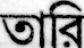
তারি
